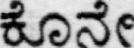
ಕೊನೇ
